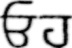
ਓਹ
